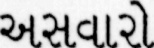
અસવારો
